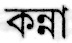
কন্না
